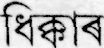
ধিক্কাৰ
